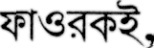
ফাওরকই,
